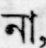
না,
